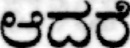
ಆದರೆ
